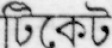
টিকেট
